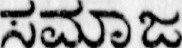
ಸಮಾಜ
